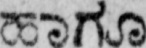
ಹಾಗೂ
